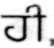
ਹੀ,
